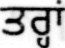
ਤਰ੍ਹਾਂ
